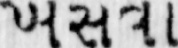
ખસવા
